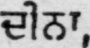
ਦੀਨਾ,
